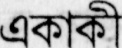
একাকী
